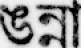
ঙন্না
